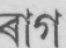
ৰাগ
